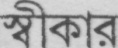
স্বীকার
